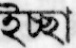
ইচ্ছা
